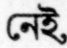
নেই,
